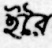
ইরৈ
